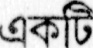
একটি
